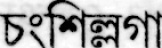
চংশিল্লগা
